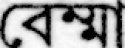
বেম্মা
